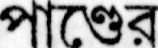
পাণ্ডের
